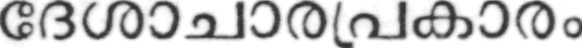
ദേശാചാരപ്രകാരം
